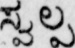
ಸ್ವಲ್ಪ
